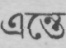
এন্তে
